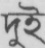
দুই
